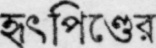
হৃৎপিণ্ডের
